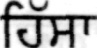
ਹਿੱਸਾ
